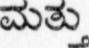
ಮತ್ತು
